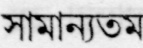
সামান্যতম
